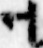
ન
